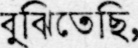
বুঝিতেছি,
